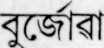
বুর্জোৱা
